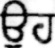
ਉਹ
